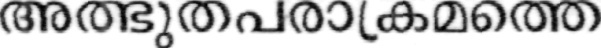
അത്ഭുതപരാക്രമത്തെ
